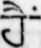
ਹੈਂ
